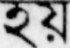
হয়
